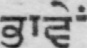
ਭਾਵੇਂ
